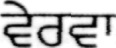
ਵੇਰਵਾ
